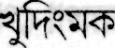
খুদিংমক
